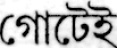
গোটেই
